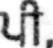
ਪੀ,
